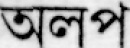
অলপ
